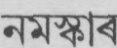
নমস্কাৰ
